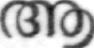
ആ
